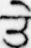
ਤੇ
